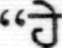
''ਹੇ
